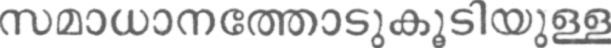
സമാധാനത്തോടുകൂടിയുള്ള
